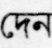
দেন
